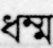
ধম্ম
